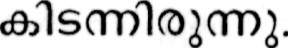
കിടന്നിരുന്നു.
